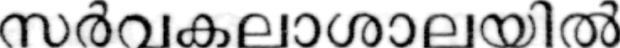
സര്‍വകലാശാലയില്‍
